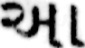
આ
